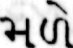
મળે
